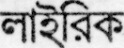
লাইরিক
